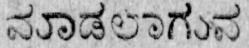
ಮಾಡಲಾಗುವ
